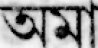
অমা
